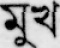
মুখ
